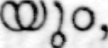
യും,
